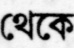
থেকে
